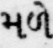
મળે
